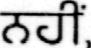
ਨਹੀਂ,
